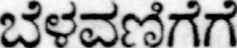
ಬೆಳವಣಿಗೆಗೆ
